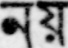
নয়
